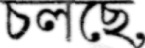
চলছে,
